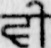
ਵੀ
